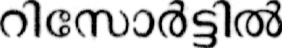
റിസോര്‍ട്ടില്‍
